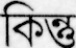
কিন্তু
